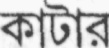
কাটার
